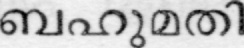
ബഹുമതി
